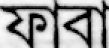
ফাবা
